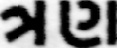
ત્રણ
